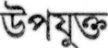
উপযুক্ত
